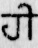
ਹੀ
